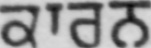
ਕਾਰਨ
